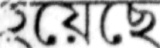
হয়েছে
